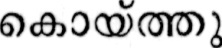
കൊയ്ത്തു
